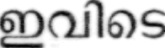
ഇവിടെ
